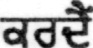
ਕਰਦੈਂ
